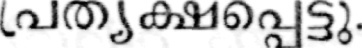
പ്രത്യക്ഷപ്പെട്ടു.
